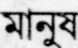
মানুষ
